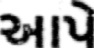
આપે
